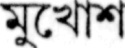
মুখোশ
